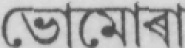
ভোমোৰা
